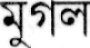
মুগল
